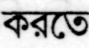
করতে
